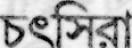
চৎসিরা
